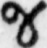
જ
